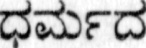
ಧರ್ಮದ
